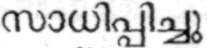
സാധിപ്പിച്ചു
